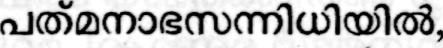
പത്മനാഭസന്നിധിയില്‍,
